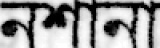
নশানা
